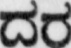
ದರ
